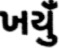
ખર્યું
